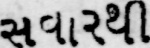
સવારથી
